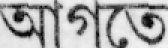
আগতে
